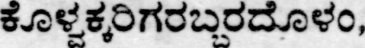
ಕೊಳ್ವಕ್ಕರಿಗರಬ್ಬರದೊಳಂ,
